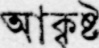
আকৃষ্ট
